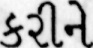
કરીને
